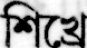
শিখ্রে
